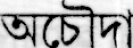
অচৌদা
